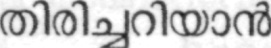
തിരിച്ചറിയാന്‍
